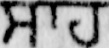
ਸਾਹ
